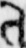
તે
